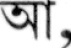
আ,
